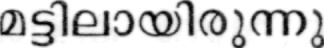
മട്ടിലായിരുന്നു
